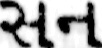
સન
